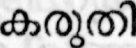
കരുതി
